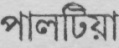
পালটিয়া
